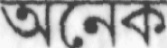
অনেক
